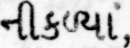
નીકળ્યા,
